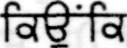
ਕਿਉਂਕਿ
